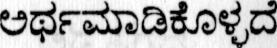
ಅರ್ಥಮಾಡಿಕೊಳ್ಳದೆ
